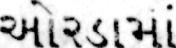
ઓરડામાં
